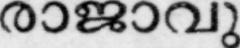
രാജാവു
